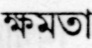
ক্ষমতা
